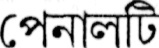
পেনালটি
